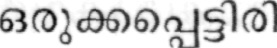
ഒരുക്കപ്പെട്ടിരി
